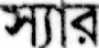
স্যার
